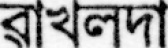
ৱাখলদা
